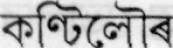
কণ্টিলৌৰ
